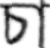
চা
